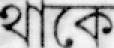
থাকে
